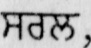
ਸਰਲ,
